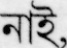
নাই,
